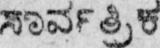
ಸಾರ್ವತ್ರಿಕ
